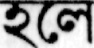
হলে
